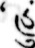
'હું
